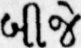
બીજે
